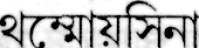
থম্মোয়সিনা
